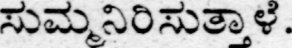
ಸುಮ್ಮನಿರಿಸುತ್ತಾಳೆ.
